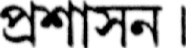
প্রশাসন।
